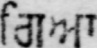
ਗਿਆ
